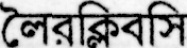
লৈরক্লিবসি
